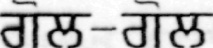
ਗੋਲ-ਗੋਲ
